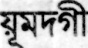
য়ূমদগী
